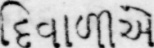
દિવાળીએ
